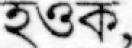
হওক,
